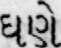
ઘણે
